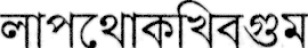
লাপথোকখিবগুম
